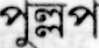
পুল্লপ
